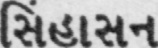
સિંહાસન
